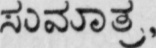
ಸುಮಾತ್ರ,
